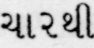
ચારથી
